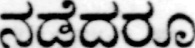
ನಡೆದರೂ
